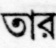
তার
